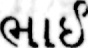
ભાઈ
